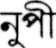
নুপী
